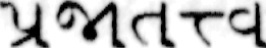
પ્રજાતત્ત્વ
